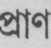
প্ৰাণ
